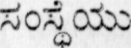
ಸಂಸ್ಥೆಯು
